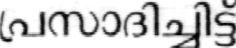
പ്രസാദിച്ചിട്ട്
